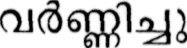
വര്‍ണ്ണിച്ചു
